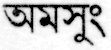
অমসুং
